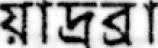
য়াদ্রব্রা
